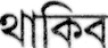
থাকিব
